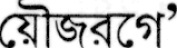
য়ৌজরগে’
